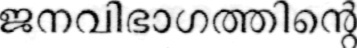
ജനവിഭാഗത്തിന്റെ
